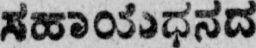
ಸಹಾಯಧನದ
